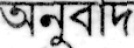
অনুবাদ
